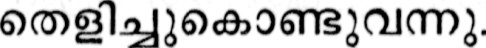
തെളിച്ചുകൊണ്ടുവന്നു.
